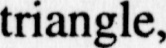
triangle,
